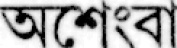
অশেংবা
